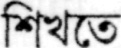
শিখতে
